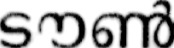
ടൌണ്‍
